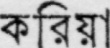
করিয়া
